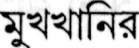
মুখখানির
